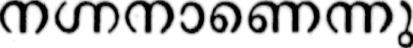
നഗ്നനാണെന്നു
